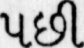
પછી
